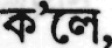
ক'লে,
